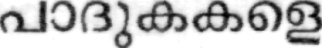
പാദുകകളെ
